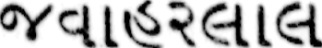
જવાહરલાલ
